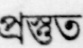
প্রস্তুত
